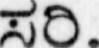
ಸರಿ.
